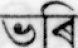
ভৰি
